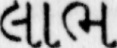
લાભ
